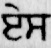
ਏਸ
